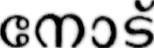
നോട്
